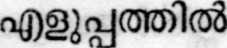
എളുപ്പത്തില്‍
